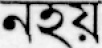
নহয়
